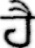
ਹੈ
